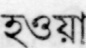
হওয়া
